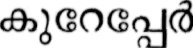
കുറേപ്പേര്‍
